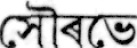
সৌৰভে
